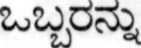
ಒಬ್ಬರನ್ನು
